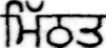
ਮਿੱਠਤ
